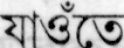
যাওঁতে
